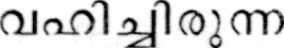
വഹിച്ചിരുന്ന
